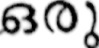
ഒരു
